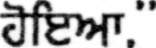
ਹੋਇਆ,''
